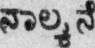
ನಾಲ್ಕನೆ
